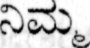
ನಿಮ್ಮ
